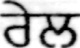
ਰੇਲ
